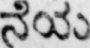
ನೆಯ
